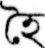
হৈ
